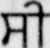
ਸੀ
